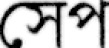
সেপ
